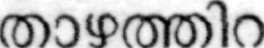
താഴത്തിറ
